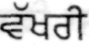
ਵੱਖਰੀ
